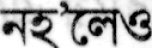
নহ'লেও
